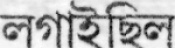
লগাইছিল
